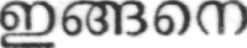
ഇങ്ങനെ
